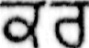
ਕਰ
